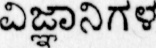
ವಿಜ್ಞಾನಿಗಳ
